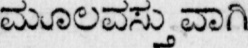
ಮೂಲವಸ್ತುವಾಗಿ
